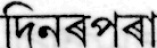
দিনৰপৰা
